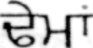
ਢੇਮਾਂ
